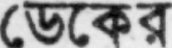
ডেকের
